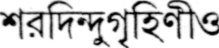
শরদিন্দুগৃহিণীও
